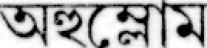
অহুম্লোম
